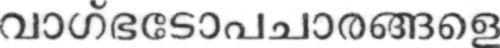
വാഗ്ഭടോപചാരങ്ങളെ
